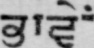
ਭਾਵੇਂ
